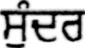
ਸੁੰਦਰ
